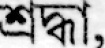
শ্রদ্ধা,
